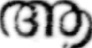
ആ
